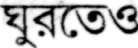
ঘুরতেও
